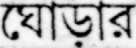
ঘোড়ার
